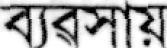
ব্যৱসায়
